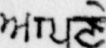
ਆਪਣੇ
